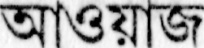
আওয়াজ
